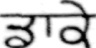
ਡਾਕੇ
